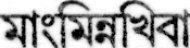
মাংমিন্নখিবা
